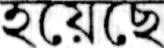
হয়েছে
